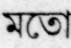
মতো
